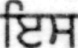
ਇਸ
